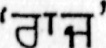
'ਰਾਜ'
